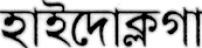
হাইদোক্লগা
